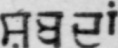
ਸ਼ਬਦਾਂ
